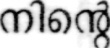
നിന്റെ
